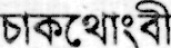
চাকথোংবী
